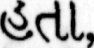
હતા,
